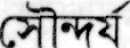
সৌন্দর্য
